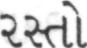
રસ્તો
